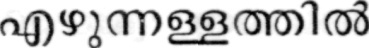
എഴുന്നള്ളത്തില്‍
